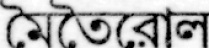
মৈতৈরোল
